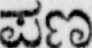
ಪಣ
